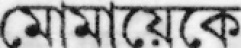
মোমায়েকে
